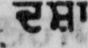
ਦਸ਼ਾ
